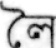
লৈ
